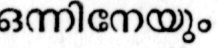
ഒന്നിനേയും
